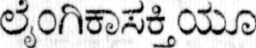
ಲೈಂಗಿಕಾಸಕ್ತಿಯೂ
